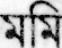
মমি
